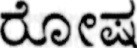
ರೋಷ
